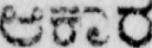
ಆಕಾರ
